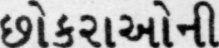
છોકરાઓની
